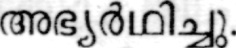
അഭ്യര്‍ഥിച്ചു.
